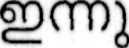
ഇന്നു
